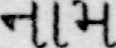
નામ
